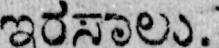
ಇರಸಾಲು.
